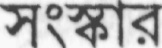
সংস্কার
